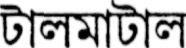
টালমাটাল
